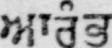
ਆਰੰਭ
